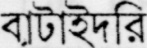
বাটাইদরি
